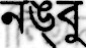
নঙবু
